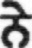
ਨੇ
